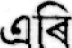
এৰি
